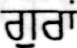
ਗੁਰਾਂ
